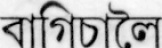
বাগিচালৈ
